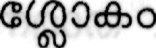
ശ്ലോകം
